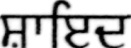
ਸ਼ਾਇਦ
